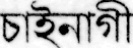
চাইনাগী
